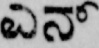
ಎನ್
